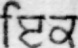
ਇਕ
